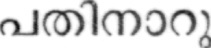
പതിനാറു
